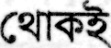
থোকই
